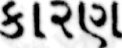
કારણ
